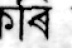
কৰি
